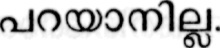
പറയാനില്ല.
